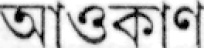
আওকাণ
